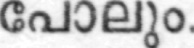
പോലും.
